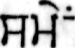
ਸਮੇਂ
